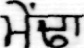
ਮੇਂਢਾ
